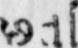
છતાં
